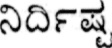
ನಿರ್ದಿಷ್ಟ
